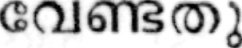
വേണ്ടതു
